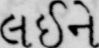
લઈને
